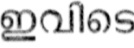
ഇവിടെ
